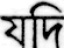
যদি
